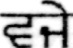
ਵਜੇ
